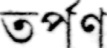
তর্পণ
